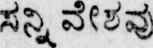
ಸನ್ನಿವೇಶವು
